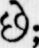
છે;
